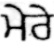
ਮੇਰੇ
